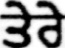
ਤੇਰੇ
